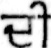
ਦੀ
